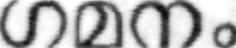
ഗമനം
